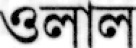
ওলাল
